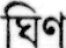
ঘিণ
